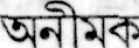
অনীমক
